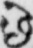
છે
